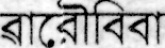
ৱারৌবিবা
